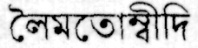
লৈমতোম্বীদি
